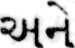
અને
